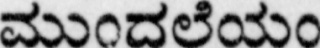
ಮುಂದಲೆಯಂ
